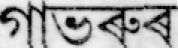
গাভৰুৰ
